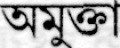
অমুক্তা
